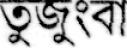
তুজুংবা
